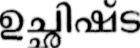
ഉച്ഛിഷ്ട
